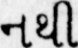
નથી
